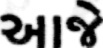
આજે
